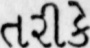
તરીકે
